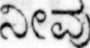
ನೀವು
